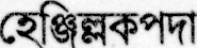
হেঞ্জিল্লকপদা
